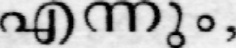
എന്നും,
